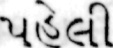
પહેલી
